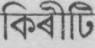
কিৰীটি
